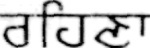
ਰਹਿਣਾ
